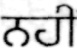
ਨਹੀਂ
